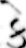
કે
